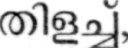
തിളച്ച്,
